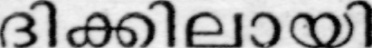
ദിക്കിലായി
